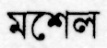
মশেল
